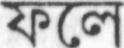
ফলে
